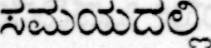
ಸಮಯದಲ್ಲಿ
